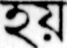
হয়
